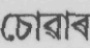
চোৱাৰ
